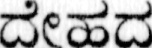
ದೇಹದ
